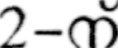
2-ന്
